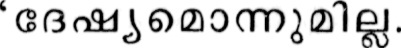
'ദേഷ്യമൊന്നുമില്ല.
